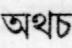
অথচ
